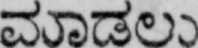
ಮಾಡಲು
